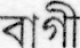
বাগী
